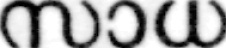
സാധ
